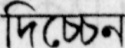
দিচ্চেন
